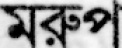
মরুপ
